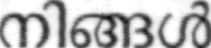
നിങ്ങള്‍
